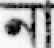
না
